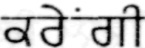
ਕਰੇਂਗੀ
